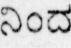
ನಿಂದ
